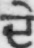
ਦੇ
